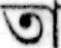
তা
